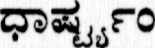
ಧಾರ್ಷ್ಟ್ಯಂ
